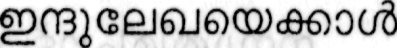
ഇന്ദുലേഖയെക്കാള്‍
